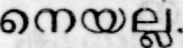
നെയല്ല.
